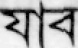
যাব
